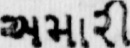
અમારી
